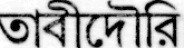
তাবীদৌরি
